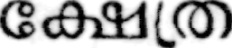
ക്ഷേത്ര
